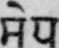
ਸੇਧ
